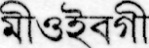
মীওইবগী
